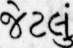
જેટલું
